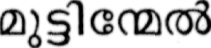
മുട്ടിന്മേല്‍
